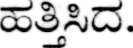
ಹತ್ತಿಸಿದ.
